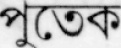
পুতেক
